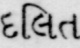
દલિત
